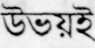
উভয়ই
